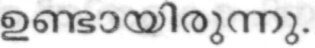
ഉണ്ടായിരുന്നു.
